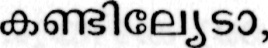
കണ്ടില്യേടാ,
